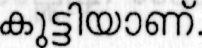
കുട്ടിയാണ്.
